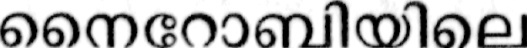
നൈറോബിയിലെ
